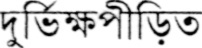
দুর্ভিক্ষপীড়িত
